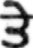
ਤੇ
